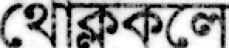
থোক্লকলে
